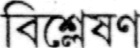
বিশ্লেষণ
